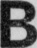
B
